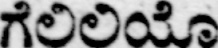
ಗೆಲಿಲಿಯೊ
